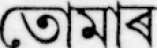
তোমাৰ
